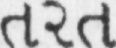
તરત
